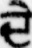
ਦੇ
